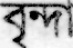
বৃন্দা
